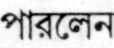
পারলেন
